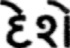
દેશે
